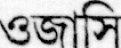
ওজাসি
